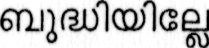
ബുദ്ധിയില്ലേ
